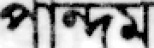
পান্দম
